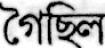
গৈছিল
